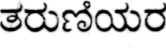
ತರುಣಿಯರ
